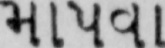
માપવા
